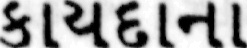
કાયદાના
